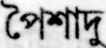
পৈশাদু
